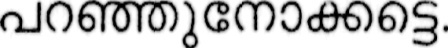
പറഞ്ഞുനോക്കട്ടെ.
